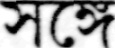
সঙ্গে
